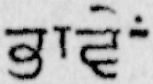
ਭਾਵੇਂ
